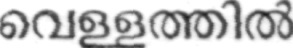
വെള്ളത്തില്‍
